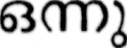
ഒന്നു
